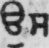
ਉਸ
